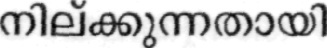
നില്ക്കുന്നതായി
